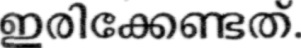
ഇരിക്കേണ്ടത്.
